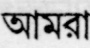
আমরা
